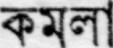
কমলা
